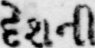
દેશની
